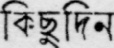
কিছুদিন
